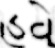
હવે
